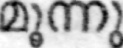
മൂന്നു
